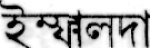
ইম্ফালদা
